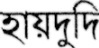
হায়দুদি
